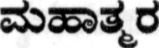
ಮಹಾತ್ಮರ
